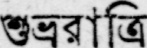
শুভ্ররাত্রি
